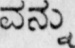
ವನ್ನು
